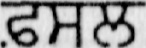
ਫ਼ਸਲ
